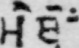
ਮੈਥੋਂ
